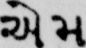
એમ
